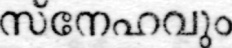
സ്നേഹവും
